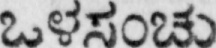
ಒಳಸಂಚು
